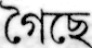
গৈছে
